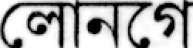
লোনগে
